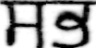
ਸਭ
